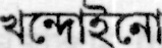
খন্দোইনো
